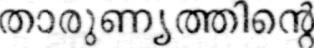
താരുണ്യത്തിന്റെ
